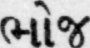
ભોજ
